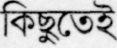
কিছুতেই
